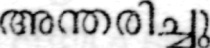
അന്തരിച്ചു
